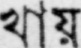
খায়
